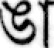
ঙা
